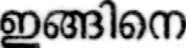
ഇങ്ങിനെ
